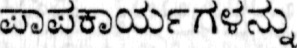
ಪಾಪಕಾರ್ಯಗಳನ್ನು
